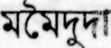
মমৈদুদা
